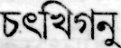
চৎখিগনু
